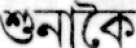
শুনাকৈ
